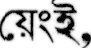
য়েংই,
